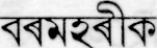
বৰমহৰীক
